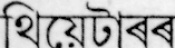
থিয়েটাৰৰ
